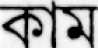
কাম
